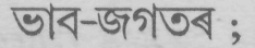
ভাব-জগতৰ;
